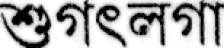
শুগৎলগা
